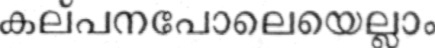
കല്പനപോലെയെല്ലാം
